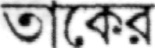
তাকের
